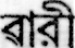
ৱারী
